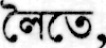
লৈতে,
